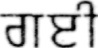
ਗਈ
